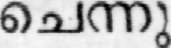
ചെന്നു
